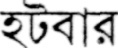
হটবার
